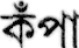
কঁপা
